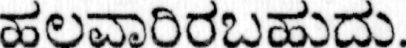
ಹಲವಾರಿರಬಹುದು.
